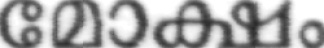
മോക്ഷം
